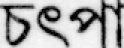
চৎপা
